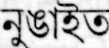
নুঙাইত
